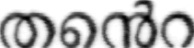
തന്റെ
